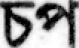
চপ
